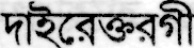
দাইরেক্তরগী
